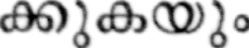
ക്കുകയും
